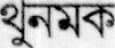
থুনমক
